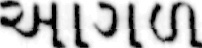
આગળ
